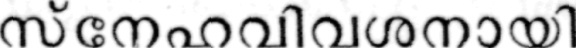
സ്നേഹവിവശനായി
